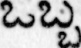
ಒಬ್ಬ
